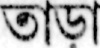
তাড়া
